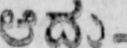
ಆದು.
